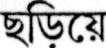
ছড়িয়ে
